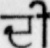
ਦੀ
